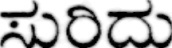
ಸುರಿದು
